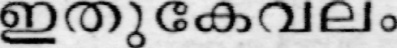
ഇതുകേവലം
